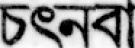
চৎনবা
